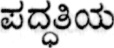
ಪದ್ಧತಿಯ
